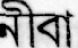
নীবা
